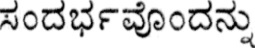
ಸಂದರ್ಭವೊಂದನ್ನು
